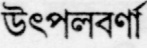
উত্পলবর্ণা
